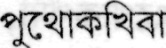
পুথোকখিবা
